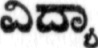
ವಿದ್ಯಾ
